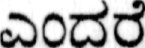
ಎಂದರೆ
